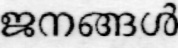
ജനങ്ങള്‍
